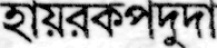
হায়রকপদুদা
